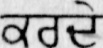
ਕਰਦੇ
